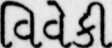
વિવેકી
